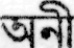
অনী
